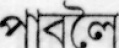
পাবলৈ
